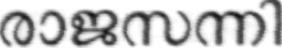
രാജസന്നി
